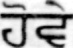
ਹੋਵੇ
